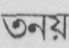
তনয়
